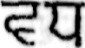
ਵਧ
